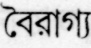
বৈরাগ্য
